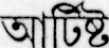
আৰ্টিষ্ট
